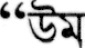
“উম
